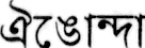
ঐঙোন্দা
